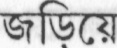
জড়িয়ে
